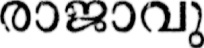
രാജാവു
